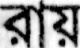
রায়
